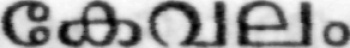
കേവലം
